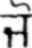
ਜੋ
